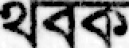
থবক
